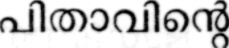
പിതാവിന്റെ
